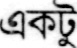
একটু
